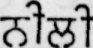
ਨੀਲੀ
